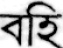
বহি
